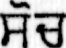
ਸੋਚ
